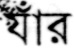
যাঁর
